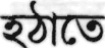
হঠাতে
